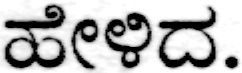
ಹೇಳಿದ.
